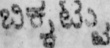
ಬಿಕ್ಕಟ್ಟು
